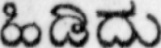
ಹಿಡಿದು
